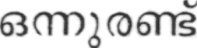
ഒന്നുരണ്ട്
